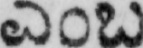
ಎಂಬ
